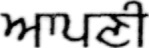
ਆਪਣੀ
